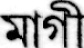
মাগী
